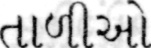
તાળીઓ
